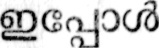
ഇപ്പോള്‍
